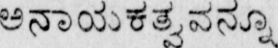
ಅನಾಯಕತ್ವವನ್ನೂ
